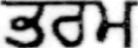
ਭਰਮ
